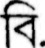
বি.
